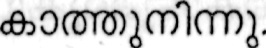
കാത്തുനിന്നു.
